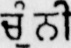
ਚੁੰਨੀ
